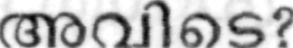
അവിടെ?
